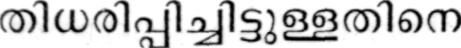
തിധരിപ്പിച്ചിട്ടുള്ളതിനെ
